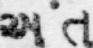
અંત
